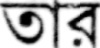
তার
